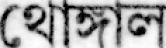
থোঙ্গাল
